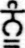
ਨੂੰ
